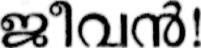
ജീവന്‍!
